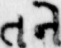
તને
